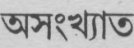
অসংখ্যাত
